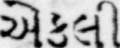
એકલી
